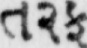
તરફ
